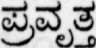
ಪ್ರವೃತ್ತ
